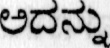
ಅದನ್ನು
